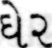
ઘેર
